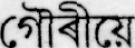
গৌৰীয়ে
